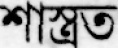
শাস্ত্রত
